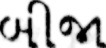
બીજા
